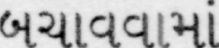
બચાવવામાં
